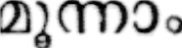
മൂന്നാം
